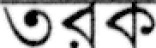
তরক
